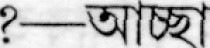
?-আচ্ছা
